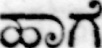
ಹಾಗೆ
